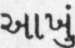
આખું
